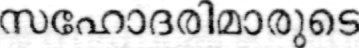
സഹോദരിമാരുടെ
